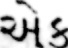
એક
